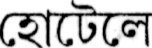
হোটেলে
